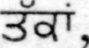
ਤੱਕਾਂ,
